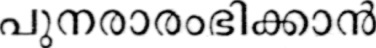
പുനരാരംഭിക്കാന്‍
